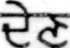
ਦੇਣ
